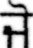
ਜੋ
